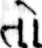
તો
